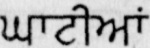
ਘਾਟੀਆਂ
